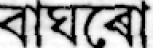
বাঘৰো
